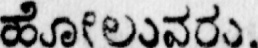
ಹೋಲುವರು.
